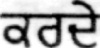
ਕਰਦੇ
